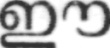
ഈ
